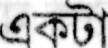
একটা
